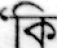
'কি
